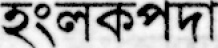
হংলকপদা
